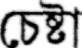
চেষ্টা
